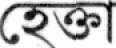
হেক্তা
